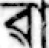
ৱা
